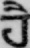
ਹੈ
